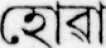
হোৱা
